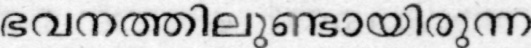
ഭവനത്തിലുണ്ടായിരുന്ന
